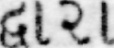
દ્વારા
